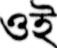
ওই
